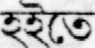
হইতে
